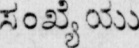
ಸಂಖ್ಯೆಯು
